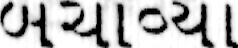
બચાવ્યા
